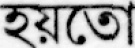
হয়তো
